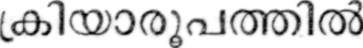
ക്രിയാരൂപത്തില്‍
